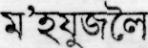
ম'হযুজলৈ
